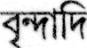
বৃন্দাদি
